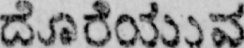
ದೊರೆಯುವ
